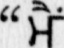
''ਮੈਂ
